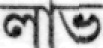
লাভ
